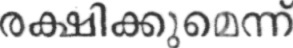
രക്ഷിക്കുമെന്ന്
